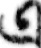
এ
